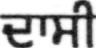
ਦਾਸੀ
